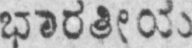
ಭಾರತೀಯ
